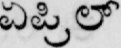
ಏಪ್ರಿಲ್
